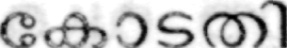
കോടതി
